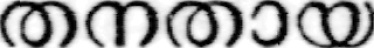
തനതായ
